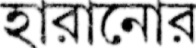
হারানোর
